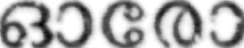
ഓരോ
